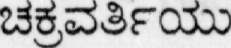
ಚಕ್ರವರ್ತಿಯು
